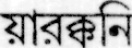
য়ারক্কনি
